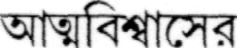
আত্মবিশ্বাসের
